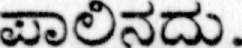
ಪಾಲಿನದು.
